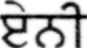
ਏਨੀ
